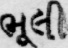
ભૂલી
